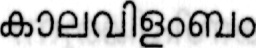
കാലവിളംബം
